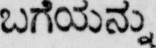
ಬಗೆಯನ್ನು
